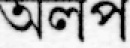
অলপ
